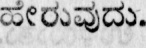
ಹೇರುವುದು.
